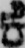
ಕೆ
